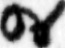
જ
